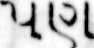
પણ
